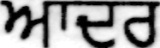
ਆਦਰ
